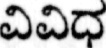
ವಿವಿಧ
